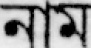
নাম
